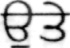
ਉਤੇ
